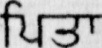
ਪਿਤਾ
